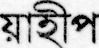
য়াহীপ
